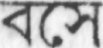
বসে
